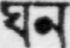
ঘন
